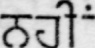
ਨਹੀਂ
